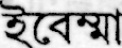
ইবেম্মা
